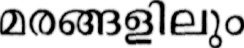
മരങ്ങളിലും
